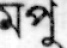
মপু
